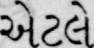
એટલે
